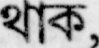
থাক,
